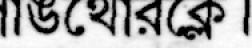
পাঙথোরক্লে
